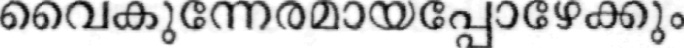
വൈകുന്നേരമായപ്പോഴേക്കും
